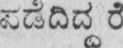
ಪಡೆದಿದ್ದರೆ
